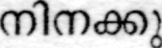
നിനക്കു
